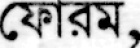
ফোরম,
